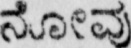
ನೋವು
